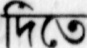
দিতে
